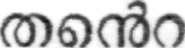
തന്റെ
